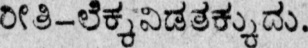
ರೀತಿ-ಲೆಕ್ಕವಿಡತಕ್ಕುದು.
